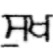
ਸੁਖ
